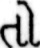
તો
